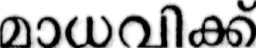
മാധവിക്ക്
